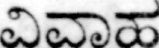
ವಿವಾಹ
